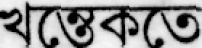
খন্তেকতে
